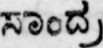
ಸಾಂದ್ರ
